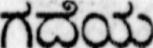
ಗದೆಯ
